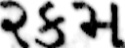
રકમ
